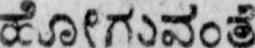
ಹೋಗುವಂತೆ
